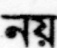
নয়
